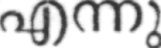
എന്നു
